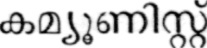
കമ്യൂണിസ്റ്റ്
